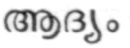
ആദ്യം
